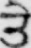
ਤੇ
